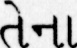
તેના
